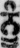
ਨੂੰ
